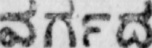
ವರ್ಗದ
